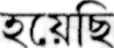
হয়েছি
